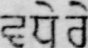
ਵਧੇਰੇ
